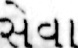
સેવા
